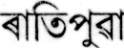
ৰাতিপুৱা
